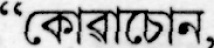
"কোৱাচোন,
